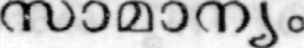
സാമാന്യം
